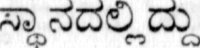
ಸ್ಥಾನದಲ್ಲಿದ್ದು
